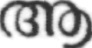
ആ
